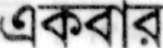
একবার
